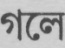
গলে
